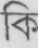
কি
